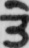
ਤੇ
